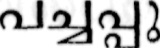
പച്ചപ്പു
